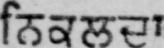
ਨਿਕਲਦਾ
